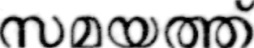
സമയത്ത്
